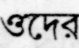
ওদের
